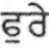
ਫੁਰੇ
